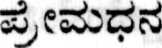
ಪ್ರೇಮಧನ
